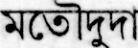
মতৌদুদা
